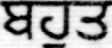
ਬਹੁਤ
